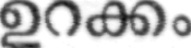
ഉറക്കം
